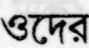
ওদের
